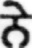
ਨੇ
